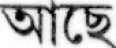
আছে
